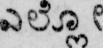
ಎಲ್ಲೋ
